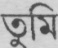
তুমি
